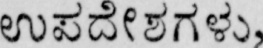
ಉಪದೇಶಗಳು,
